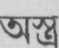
অস্ত্ৰ
